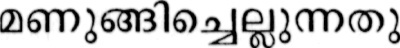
മണുങ്ങിച്ചെല്ലുന്നതു
